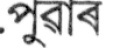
পুৱাৰ
